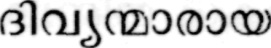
ദിവ്യന്മാരായ
